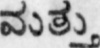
ಮತ್ತು
